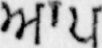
ਆਪ
